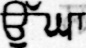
ਉੱਘਾ
